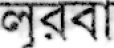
লূরবা
